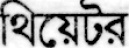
থিয়েটর
